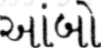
આંબો
